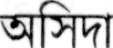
অসিদা
